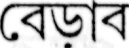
বেড়াব
